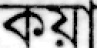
কয়া
